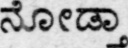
ನೋಡ್ತಾ
